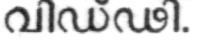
വിഡ്ഢി.
